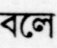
বলে
